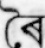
ৰৈ
